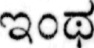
ಇಂಥ
